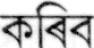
কৰিব
